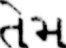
તેમ
